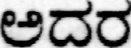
ಅದರ
